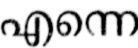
എന്നെ
